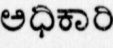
ಅಧಿಕಾರಿ
